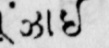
મૂંઝાઈ
